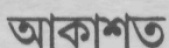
আকাশত
